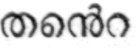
തന്റെ
